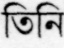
তিনি
